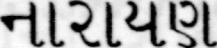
નારાયણ
